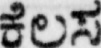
ಕೆಲಸ
